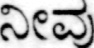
ನೀವು
